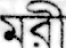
মরী
